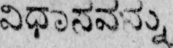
ವಿಧಾನವನ್ನು
